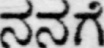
ನನಗೆ
